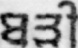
ਬੜੀ
